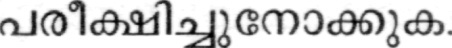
പരീക്ഷിച്ചുനോക്കുക.
